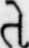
તે
